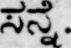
ಸನ್ನೆ.
